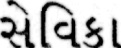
સેવિકા
